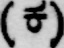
(ಕ)
